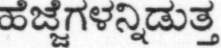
ಹೆಜ್ಜೆಗಳನ್ನಿಡುತ್ತ
